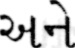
અને
